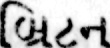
બ્રિટન
